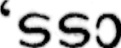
‘ടടാ
